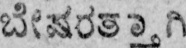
ಬೇಷರತ್ತಾಗಿ
